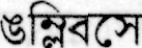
ঙম্লিবসে
